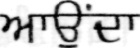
ਆਉਂਦਾ
